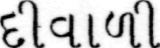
દીવાળી
